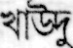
খাউদু
